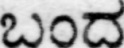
ಬಂದ
